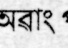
অৱাং
